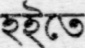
হইতে
